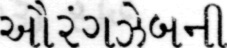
ઔરંગઝેબની
